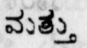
ಮತ್ತು
